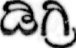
ಡಿಗ್ರಿ
